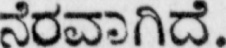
ನೆರವಾಗಿದೆ.
